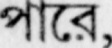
পারে,
